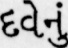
દવેનું
